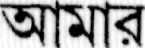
আমার
